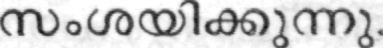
സംശയിക്കുന്നു.
